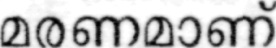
മരണമാണ്
